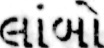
લાંબો
